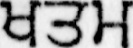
ਖਤਮ
